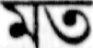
মত
